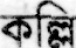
কল্লি
